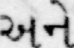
અને
